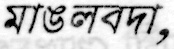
মাঙলবদা,
